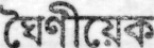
ঘৈণীয়েক
